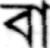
বা
